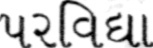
પરવિદ્યા
